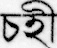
চহী
